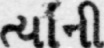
ત્યાંની
